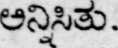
ಅನ್ನಿಸಿತು.
